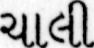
ચાલી
